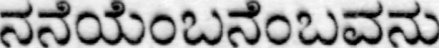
ನನೆಯೆಂಬನೆಂಬವನು
